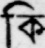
কি
